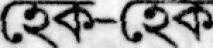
হেক-হেক
